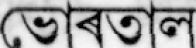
ভোৰতাল
